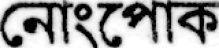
নোংপোক
